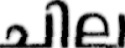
ചില
